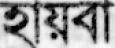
হায়বা
